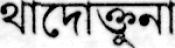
থাদোক্তুনা
